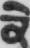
ਕੇ
